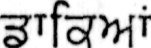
ਡਾਕਿਆਂ
